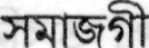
সমাজগী
